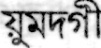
য়ুমদগী
